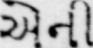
એની
